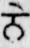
ਨੇ
